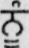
ਨੂੰ
